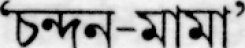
'চন্দন-মামা'
